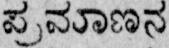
ಪ್ರಮಾಣನ
